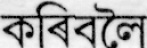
কৰিবলৈ
